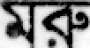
মরু
